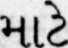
માટે
